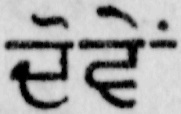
ਦੋਵੇਂ
